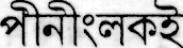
পীনীংলকই
